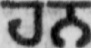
ਹਨ
